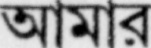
আমার
